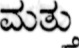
ಮತ್ತು
